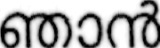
ഞാന്‍
